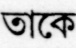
তাকে
